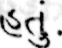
હતું.
